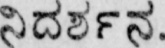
ನಿದರ್ಶನ.
